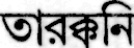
তারক্কনি
